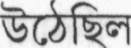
উঠেছিল
